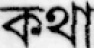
কথা
